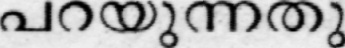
പറയുന്നതു
